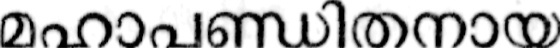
മഹാപണ്ഡിതനായ
